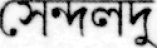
সেন্দলদু
